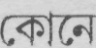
কোনে
